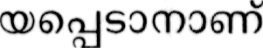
യപ്പെടാനാണ്
